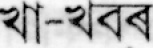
খা-খবৰ
